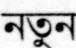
নতুন
